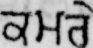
ਕਮਰੇ
